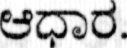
ಆಧಾರ.
